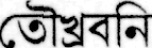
তৌখ্রবনি
